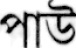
পাউ
